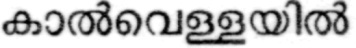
കാല്‍വെള്ളയില്‍
